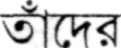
তাঁদের
